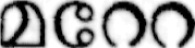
മറേറ
